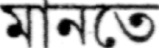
মানতে
